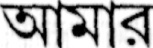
আমার
